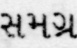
સમગ્ર
